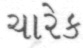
ચારેક
